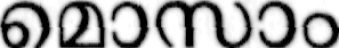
മൊസാം
